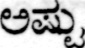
ಅಷ್ಟು
